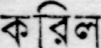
করিল
